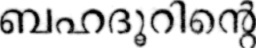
ബഹദൂറിന്റെ
